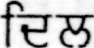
ਦਿਲ
